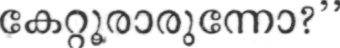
കേറ്റൂരാരുന്നോ?"
